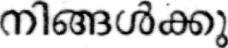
നിങ്ങള്‍ക്കു
